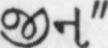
જીન"
